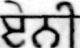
ਏਨੀ
